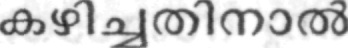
കഴിച്ചതിനാല്‍
